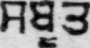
ਸਬੂਤ
